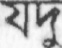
যদু
